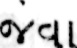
જવા
